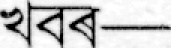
খবৰ-
